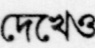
দেখেও
